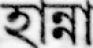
হান্না
